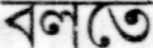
বলতে
